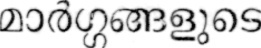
മാര്‍ഗ്ഗങ്ങളുടെ
